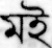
মই
